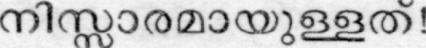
നിസ്സാരമായുള്ളത്!
